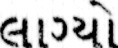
લાગ્યો
